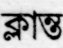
ক্লান্ত
